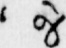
'જે
